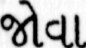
જોવા
